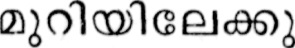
മുറിയിലേക്കു
